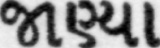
જાણ્યા
